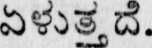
ಏಳುತ್ತದೆ.
